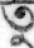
তু
